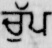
ਚੁੱਪ
